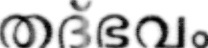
തദ്ഭവം
